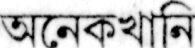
অনেকখানি
